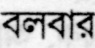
বলবার
